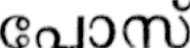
പോസ്
